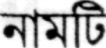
নামটি
